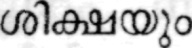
ശിക്ഷയും
